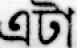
এটা
